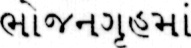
ભોજનગૃહમાં
